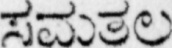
ಸಮತಲ
